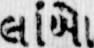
લાંબો
